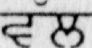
ਵੱਲ
